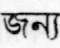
জন্য
